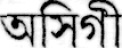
অসিগী
